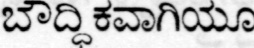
ಬೌದ್ಧಿಕವಾಗಿಯೂ
